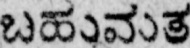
ಬಹುಮತ
